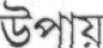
উপায়
